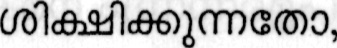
ശിക്ഷിക്കുന്നതോ,
